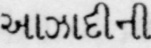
આઝાદીની
